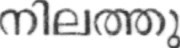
നിലത്തു
